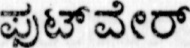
ಫುಟ್‌ವೇರ್
